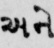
અને
